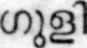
ഗുളി
